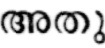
അതു
